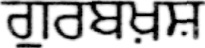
ਗੁਰਬਖ਼ਸ਼
